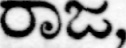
ರಾಜ,
